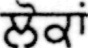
ਲੋਕਾਂ
